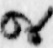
જ
